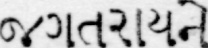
જગતરાયને
